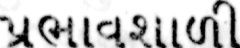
પ્રભાવશાળી
